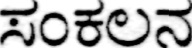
ಸಂಕಲನ
